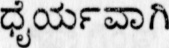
ಧೈರ್ಯವಾಗಿ
